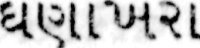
ઘણાખરા
